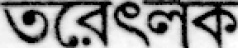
তরেৎলক
